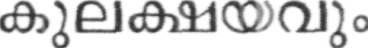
കുലക്ഷയവും
